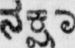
ನಕ್ಷಾ
